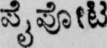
ಪೈಪೋಟಿ
